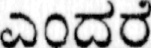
ಎಂದರೆ
